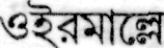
ওইরমাল্লে
